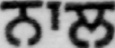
ਨਾਲ
